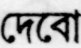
দেবো
